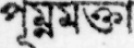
পূম্নমক্তা
